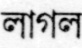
লাগল
